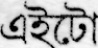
এইটো
